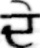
ਦੇ
